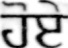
ਹੋਏ
